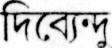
দিব্যেন্দু
